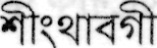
শীংথাবগী
